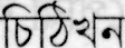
চিঠিখন
